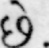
છે.
